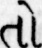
તો
